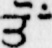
ਤੋਂ
